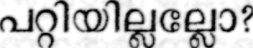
പറ്റിയില്ലല്ലോ?
